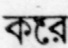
করে
